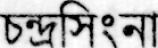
চন্দ্রসিংনা
